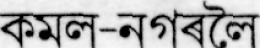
কমল-নগৰলৈ
